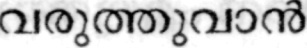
വരുത്തുവാന്‍
